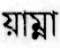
য়াম্না
